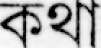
কথা
